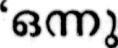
‘ഒന്നു
